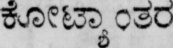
ಕೋಟ್ಯಾಂತರ
